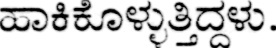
ಹಾಕಿಕೊಳ್ಳುತ್ತಿದ್ದಳು.
